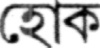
হোক
